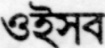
ওইসব
